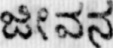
ಜೀವನ
